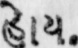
હોય.
